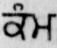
ਕੰਮ
